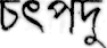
চৎপদু
